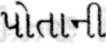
પોતાની
